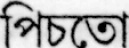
পিচতো
